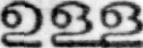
ഉള്ള
